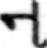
ન
